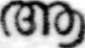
ആ
